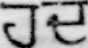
ਹਦ
